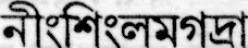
নীংশিংলমগদ্রা
